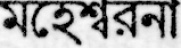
মহেশ্বরনা
